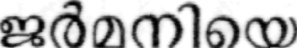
ജര്‍മനിയെ
